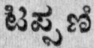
ಟಿಪ್ಪಣಿ
